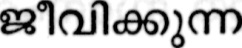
ജീവിക്കുന്ന
